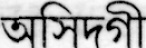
অসিদগী
